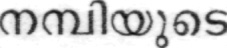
നമ്പിയുടെ
